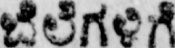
ಬೆಲೆಗಳಿಗೆ
